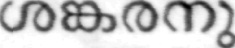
ശങ്കരനു
